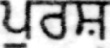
ਪੁਰਸ਼
